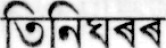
তিনিঘৰৰ
